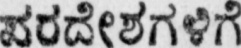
ಪರದೇಶಗಳಿಗೆ
